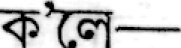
ক'লে-
